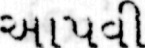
આપવી
